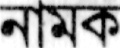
নামক
